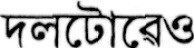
দলটোৱেও
